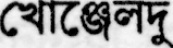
খোঞ্জেলদু
